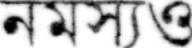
নমস্যও
